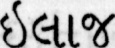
ઇલાજ
